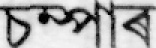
চম্পাৰ
